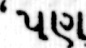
'પણ
